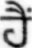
ਹੈਂ
